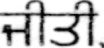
ਜੀਤੀ,
